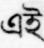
এই
